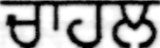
ਚਾਹਲ
